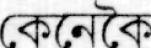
কেনেকৈ
